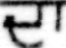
ਦਾ
